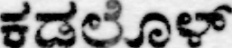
ಕಡಲೊಳ್
